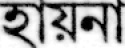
হায়না
